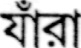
যাঁরা
